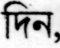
দিন,
